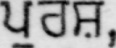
ਪੁਰਸ਼,
